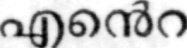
എന്റെ
